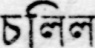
চলিল
